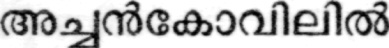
അച്ചന്‍കോവിലില്‍
